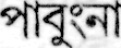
পাবুংনা
